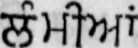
ਲੰਮੀਆਂ
